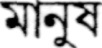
মানুষ
